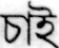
চাই
